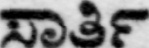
ಸಾರ್ತಿ
